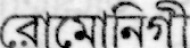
রোমোনিগী
